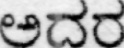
ಅದರ
